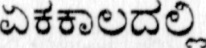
ಏಕಕಾಲದಲ್ಲಿ
